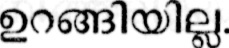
ഉറങ്ങിയില്ല.
